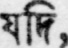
যদি,
